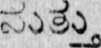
ಮತ್ತು
